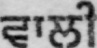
ਵਾਲੀ
